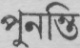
পুনন্তি
